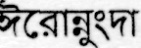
ঈরোন্নুংদা
